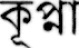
কূপ্না
